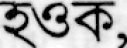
হওক,
